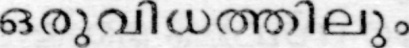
ഒരുവിധത്തിലും
